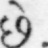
છે.
